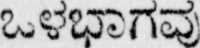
ಒಳಭಾಗವು
